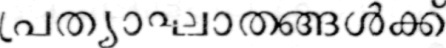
പ്രത്യാഘാതങ്ങള്‍ക്ക്
